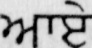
ਆਏ
